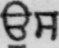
ਉਸ
